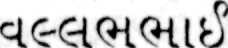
વલ્લભભાઈ
